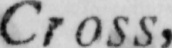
Cross,
